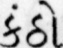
કંઠો
